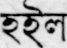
হইল
